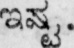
ಇಷ್ಟ.
